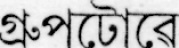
গ্রুপটোৱে
